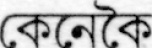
কেনেকৈ
